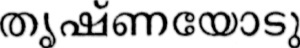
തൃഷ്ണയോടു
